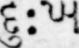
દુઃખ
